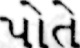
પોતે
